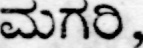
ಮಗರಿ,
